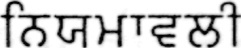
ਨਿਯਮਾਵਲੀ
